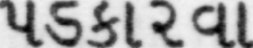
પડકારવા
